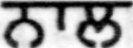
ਨਾਲ
